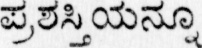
ಪ್ರಶಸ್ತಿಯನ್ನೂ
